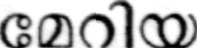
മേറിയ
